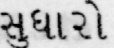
સુધારો
